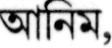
আনিম,
